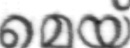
മെയ്
